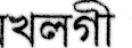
মখলগী
